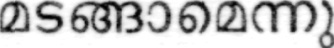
മടങ്ങാമെന്നു
